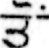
ਤੋਂ
